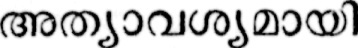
അത്യാവശ്യമായി
